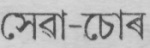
সেৱা-চোৰ
